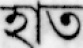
হাত
